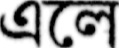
এলে
